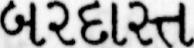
બરદાસ્ત
